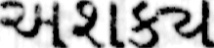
અશક્ય
